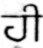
ਹੀ
